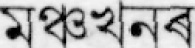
মঞ্চখনৰ
